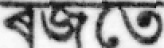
ৰজতে
